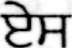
ਏਸ
